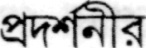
প্রদর্শনীর
